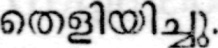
തെളിയിച്ചു.
